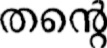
തന്റെ
